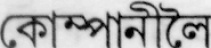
কোম্পানীলৈ
